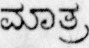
ಮಾತ್ರ
